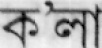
ক'লা
